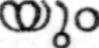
യും
